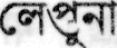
লেপ্তুনা
